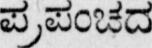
ಪ್ರಪಂಚದ
